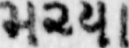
મચ્યા
